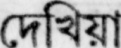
দেখিয়া
